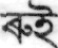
ৰুই
